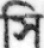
সি
